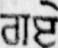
ਗਏ
